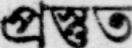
প্রস্তুত
